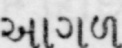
આગળ
